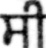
ਸੀ
